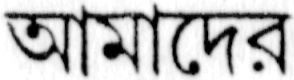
আমাদের
